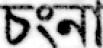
চংনা
